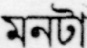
মনটা
